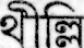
থীল্লি
